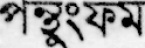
পন্থুংফম
